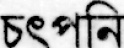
চৎপনি
